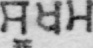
ਸੂਖਮ
